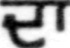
ਦਾ
